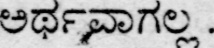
ಅರ್ಥವಾಗಲ್ಲ.
